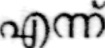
എന്ന്
